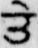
ਤੇ
